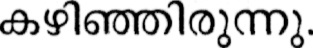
കഴിഞ്ഞിരുന്നു.
